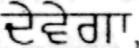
ਦੇਵੇਗਾ,
